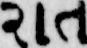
રાત
